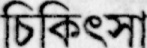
চিকিৎসা
